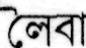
লৈবা
